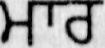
ਮਾਰ
